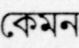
কেমন
